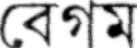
বেগম
